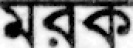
মরক
